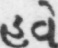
હવે
